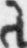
તે
